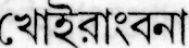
খোইরাংবনা
